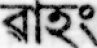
ৱাহং
